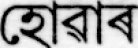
হোৱাৰ
